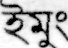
ইমুং
